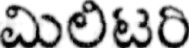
ಮಿಲಿಟರಿ
